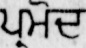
ਪ੍ਰਮੋਦ
